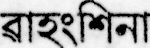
ৱাহংশিনা
